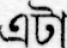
এটা
